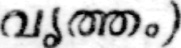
വൃത്തം)
